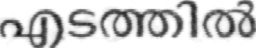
എടത്തില്‍
